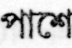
পাশে
